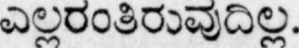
ಎಲ್ಲರಂತಿರುವುದಿಲ್ಲ.
